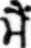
ਮੈਂ
